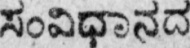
ಸಂವಿಧಾನದ
